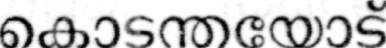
കൊടന്തയോട്
